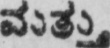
ಮತ್ತು
